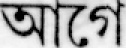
আগে
